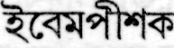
ইবেমপীশক
